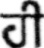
ਹੀ
